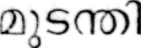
മുടന്തി
